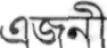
এজনী
